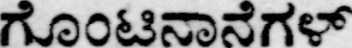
ಗೊಂಟಿನಾನೆಗಳ್
